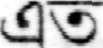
এত
